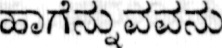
ಹಾಗೆನ್ನುವವನು
